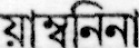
য়াম্বনিনা
